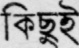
কিছুই
